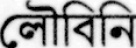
লৌবিনি
